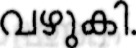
വഴുകി.
